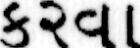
કરવા
